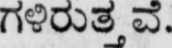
ಗಳಿರುತ್ತವೆ.
